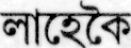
লাহেকৈ
